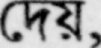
দেয়,
